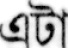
এটা
